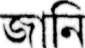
জানি
